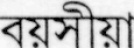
বয়সীয়া
